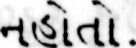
નહોતો.
